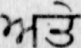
ਅਤੇ
